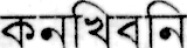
কনখিবনি
